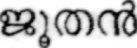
ജൂതന്‍
